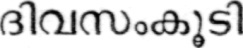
ദിവസംകൂടി
